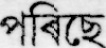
পৰিছে
